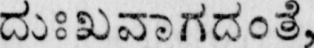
ದುಃಖವಾಗದಂತೆ,
